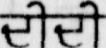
ਦੀਦੀ
